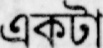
একটা
